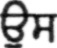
ਉਸ
